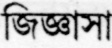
জিজ্ঞাসা
